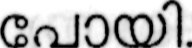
പോയി.
